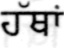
ਹੱਥਾਂ
